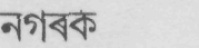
নগৰক
